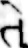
તે
